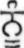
ਨੂੰ
